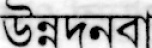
উন্নদনবা
